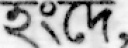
হংদে,
